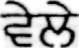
ਵੇਲੇ
